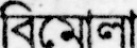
বিমোলা
